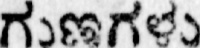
ಗುಣಗಳು
